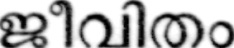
ജീവിതം
